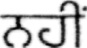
ਨਹੀਂ
